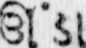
ઊંડા
